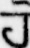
ਹੋ
